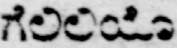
ಗೆಲಿಲಿಯೊ
